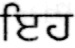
ਇਹ
